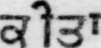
ਕੀਤਾ
